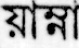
য়াম্না
